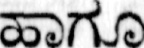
ಹಾಗೂ
